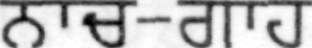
ਨਾਚ-ਗਾਹ
